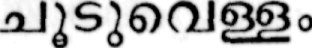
ചൂടുവെള്ളം
